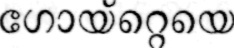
ഗോയ്റ്റെയെ
